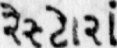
રેસ્ટોરાં
